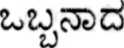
ಒಬ್ಬನಾದ
